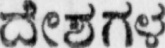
ದೇಶಗಳ
